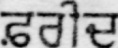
ਫ਼ਰੀਦ
